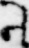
ને
